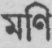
মণি
